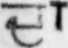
ਦਾ
